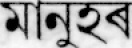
মানুহৰ
